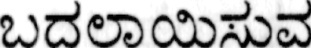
ಬದಲಾಯಿಸುವ
